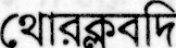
থোরক্লবদি
